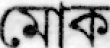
মোক
